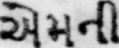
એમની
